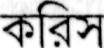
করিস
